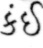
કંઈ
